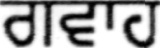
ਗਵਾਹ
